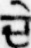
ਦੇ
